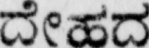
ದೇಹದ
